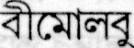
বীমোলবু
